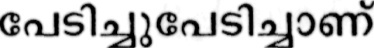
പേടിച്ചുപേടിച്ചാണ്
